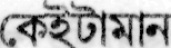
কেইটামান
